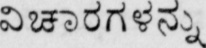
ವಿಚಾರಗಳನ್ನು
